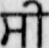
ਸੀ
